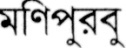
মণিপুরবু
